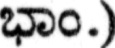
ಭಾಂ.)
